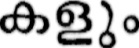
കളും
